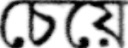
চেয়ে
